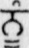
ਨੂੰ
